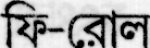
ফি-রোল
